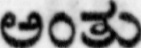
ಅಂತು
